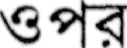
ওপর
